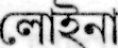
লোইনা
